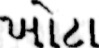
ખોટા
